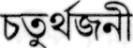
চতুর্থজনী
